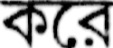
করে
